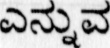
ಎನ್ನುವ
